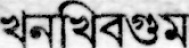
খনখিবগুম
